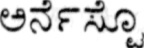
ಅರ್ನೆಸ್ಟೊ
